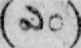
(ಎಂ)
